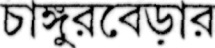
চাঙ্গুরবেড়ার
